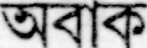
অবাক
